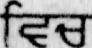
ਵਿਚ
